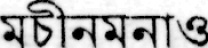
মচীনমনাও
